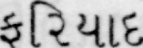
ફરિયાદ
